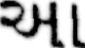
આ
